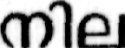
നില
